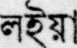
লইয়া
